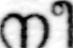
നീ
